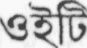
ওইটি
